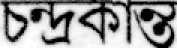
চন্দ্রকান্ত
